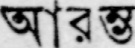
আরম্ভ
